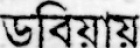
ডবিয়ায়
